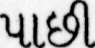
પાછી
